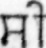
ਸੀ
